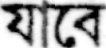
যাবে
